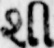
શી
